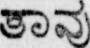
ತಾವು
